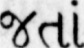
જતાં
